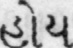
હોય
